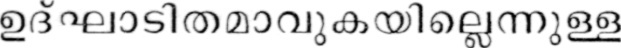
ഉദ്ഘാടിതമാവുകയില്ലെന്നുള്ള
